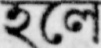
হলে
